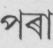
পৰা
